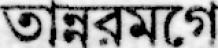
তান্নরমগে
